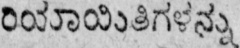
ರಿಯಾಯಿತಿಗಳನ್ನು
